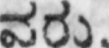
ವರು.
